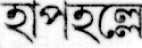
হাপহল্লে
